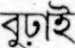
বুঢ়াই
